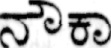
ನೌಕಾ
